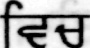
ਵਿਚ
